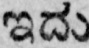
ಇದು
